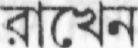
রাখেন
